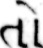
તો
